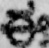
ಈ
